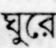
ঘুরে
